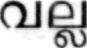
വല്ല
